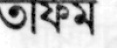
তৌফম
